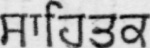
ਸਾਹਿਤਕ
